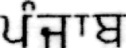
ਪੰਜਾਬ
